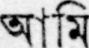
আমি
